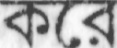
করে
